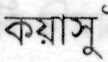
কয়াসু
